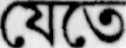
যেতে
